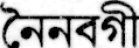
নৈনবগী
